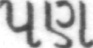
પણ
